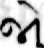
જો
